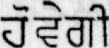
ਹੋਵੇਗੀ
